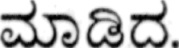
ಮಾಡಿದ.
